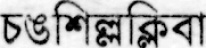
চঙশিল্লক্লিবা
